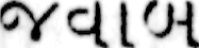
જવાબ
